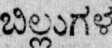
ಬಿಲ್ಲುಗಳ
